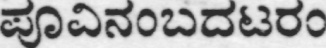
ಪೂವಿನಂಬದಟರಂ
